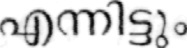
എന്നിട്ടും
